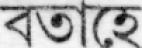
বতাহে
